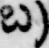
ಬ)
